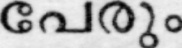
പേരും
